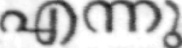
എന്നു
